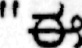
“ಈ
